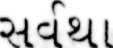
સર્વથા
